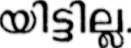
യിട്ടില്ല.
